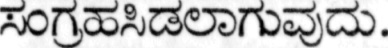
ಸಂಗ್ರಹಸಿಡಲಾಗುವುದು.
